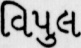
વિપુલ
